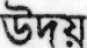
উদয়
